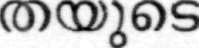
തയുടെ
